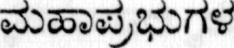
ಮಹಾಪ್ರಭುಗಳ
